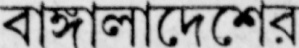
বাঙ্গালাদেশের
